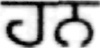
ਹਨ
